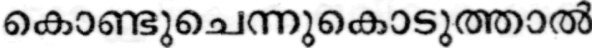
കൊണ്ടുചെന്നുകൊടുത്താല്‍
